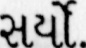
સર્યો.
